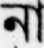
না
